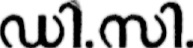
ഡി.സി.
